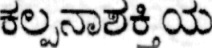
ಕಲ್ಪನಾಶಕ್ತಿಯ
